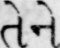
તેને
